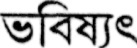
ভবিষ্যৎ
